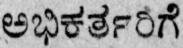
ಅಭಿಕರ್ತರಿಗೆ
